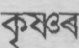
কৃষ্ণৰ
